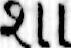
શા
